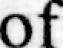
of
